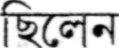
ছিলেন
